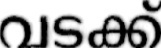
വടക്ക്
